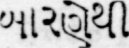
બારણેથી
